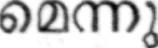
മെന്നു
